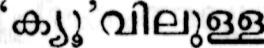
'ക്യൂ'വിലുള്ള
